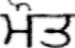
ਮੌਤ
